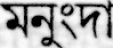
মনুংদা
